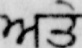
ਅਤੇ
